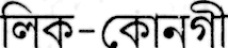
লিক-কোনগী
